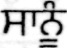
ਸਾਨੂੰ
